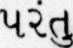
પરંતુ
